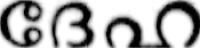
ദേഹ
